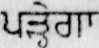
ਪੜ੍ਹੇਗਾ
